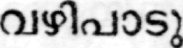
വഴിപാടു
